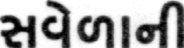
સવેળાની
